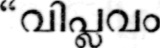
“വിപ്ലവം
